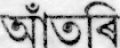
আঁতৰি
